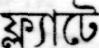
ফ্ল্যাটে
